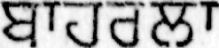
ਬਾਹਰਲਾ
